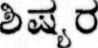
ಶಿಷ್ಯರ
